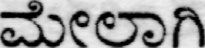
ಮೇಲಾಗಿ
